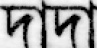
দাদা
